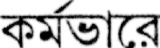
কর্মভারে
